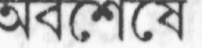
অবশেষে
